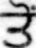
ਤੋਂ
